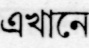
এখানে
